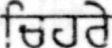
ਚਿਹਰੇ
